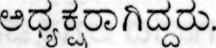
ಅಧ್ಯಕ್ಷರಾಗಿದ್ದರು.
